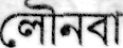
লৌনবা
